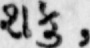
શકુ
